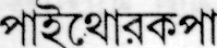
পাইথোরকপা
